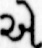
એ
